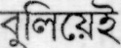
বুলিয়েই
